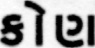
કોણ
